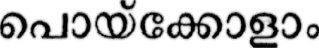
പൊയ്ക്കോളാം
